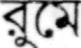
রুমে
